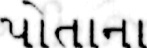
પોતાના
